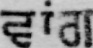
ਵਾਂਗ
